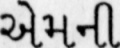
એમની
